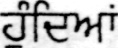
ਹੁੰਦਿਆਂ
